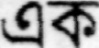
এক
